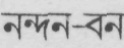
নন্দন-বন
